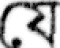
যে
